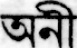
অনী
